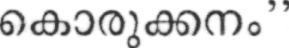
കൊരുക്കനം”
